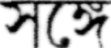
সঙ্গে
